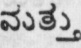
ಮತ್ತು
